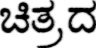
ಚೆತ್ರದ
